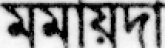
মমায়দা
